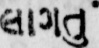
લાગતું
